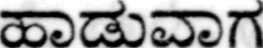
ಹಾಡುವಾಗ
